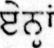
ਏਨ੍ਹਾਂ
